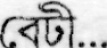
বেটী...
